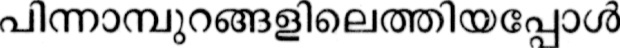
പിന്നാമ്പുറങ്ങളിലെത്തിയപ്പോള്‍
